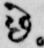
છે.
